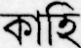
কাহি
